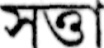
সত্তা
